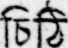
চিঠি
